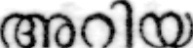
അറിയ
